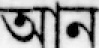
আন
